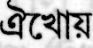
ঐখোয়
